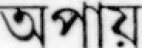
অপায়
